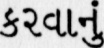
કરવાનું
